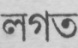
লগত
